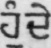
ਹੁੰਦੇ
